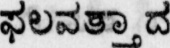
ಫಲವತ್ತಾದ
